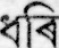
ধৰি
